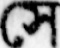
সে
